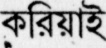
করিয়াই
